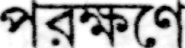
পরক্ষণে
